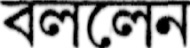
বললেন
